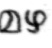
മഴ
